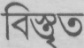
বিস্তৃত
